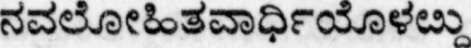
ನವಲೋಹಿತವಾರ್ಧಿಯೊಳೞ್ದು
